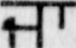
ਜਾ
